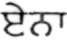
ਏਨਾ
